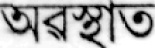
অৱস্থাত
